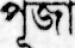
পূজা
